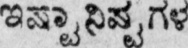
ಇಷ್ಟಾನಿಷ್ಟಗಳ
